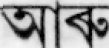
আৰু
